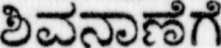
ಶಿವನಾಣೆಗೆ
